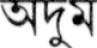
অদুম
